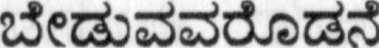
ಬೇಡುವವರೊಡನೆ
